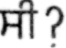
ਸੀ?
